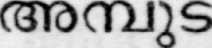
അമ്പുട
